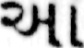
આ
